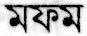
মফম
